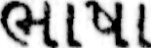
ભાષા
